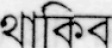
থাকিব
